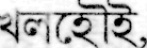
খলহৌই,
